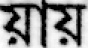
য়ায়
